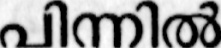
പിന്നില്‍
